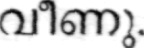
വീണു.
